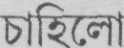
চাহিলো
